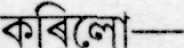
কৰিলো-
